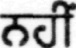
ਨਹੀਂ
